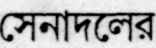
সেনাদলের
